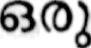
ഒരു
